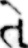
તે
